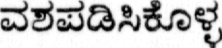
ವಶಪಡಿಸಿಕೊಳ್ಳ
